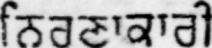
ਨਿਰਣਾਕਾਰੀ
